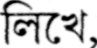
লিখে,
